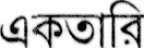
একতারি
